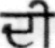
ਦੀ
